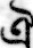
ঐ
